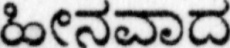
ಹೀನವಾದ
